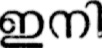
ഇനി
